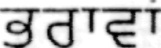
ਭਰਾਵਾਂ
